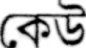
কেউ
